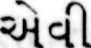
એવી
